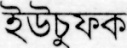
ইউচুফক
